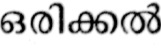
ഒരിക്കല്‍
